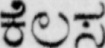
ಕೆಲಸ
